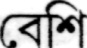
বেশি
